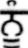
ਨੂੰ
